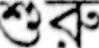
শুরু
